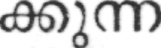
ക്കുന്ന
